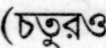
(চতুরও
